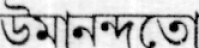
উমানন্দতো
